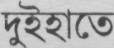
দুইহাতে
